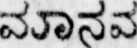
ಮಾನವ
